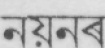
নয়নৰ
